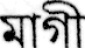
মাগী
